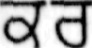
ਕਰ
